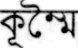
কূম্মৈ
